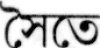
সৈতে
